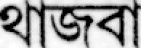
থাজবা
